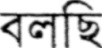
বলছি
